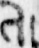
તો
